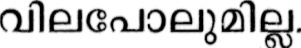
വിലപോലുമില്ല.
